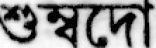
শুম্বদো
